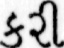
કરી
